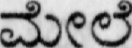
ಮೇಲೆ
